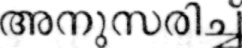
അനുസരിച്ച്
